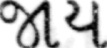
જાય
